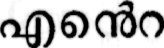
എന്റെ
